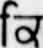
ਕਿ
